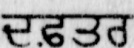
ਦਫ਼ਤਰ
